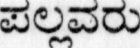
ಪಲ್ಲವರು
